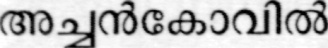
അച്ചന്‍കോവില്‍
